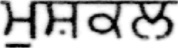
ਮੁਸ਼ਕਲ
